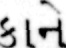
કાને
